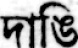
দাঙি
